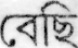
বেছি
